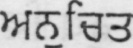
ਅਨੁਚਿਤ
